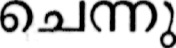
ചെന്നു
